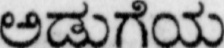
ಅಡುಗೆಯ
